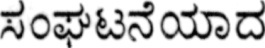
ಸಂಘಟನೆಯಾದ
